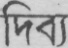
দিব্য
